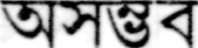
অসম্ভব
